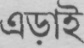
এড়াই
